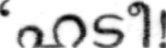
'ഹടീ!
